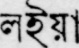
লইয়া
